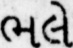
ભલે
